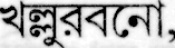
খল্লুরবনো,
